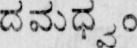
ದಮಧ್ವಂ
